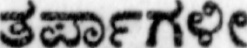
ತರ್ಪಾಗಳೀ
